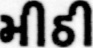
મીઠી
